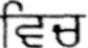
ਵਿਚ
